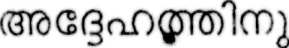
അദ്ദേഹത്തിനു
